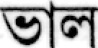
ভাল
